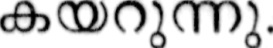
കയറുന്നു.
